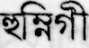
হুম্নিগী
